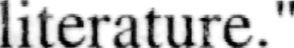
literature."
